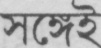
সঙ্গেই
